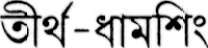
তীর্থ-ধামশিং
